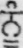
ਨੂੰ
